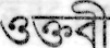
ওক্তবী
